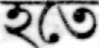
হতে
